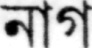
নাগ
